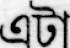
এটা
